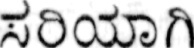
ಸರಿಯಾಗಿ
